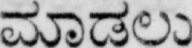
ಮಾಡಲು
